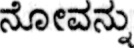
ನೋವನ್ನು
